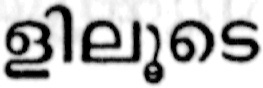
ളിലൂടെ
